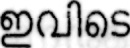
ഇവിടെ
